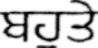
ਬਹੁਤੇ
